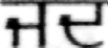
ਜਦ
